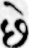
છે
